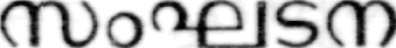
സംഘടന
